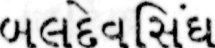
બલદેવસિંઘ
